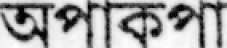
অপাকপা
